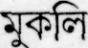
মুকলি
